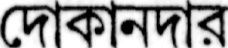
দোকানদার
